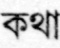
কথা
